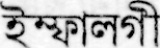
ইম্ফালগী
